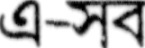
এ-সব
